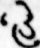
'હે
